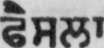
ਫੈਸਲਾ
